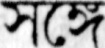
সঙ্গে
